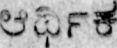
ಆರ್ಥಿಕ
